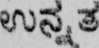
ಉನ್ನತ
